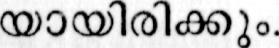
യായിരിക്കും.
